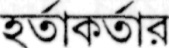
হর্তাকর্তার
